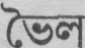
ভৈল
